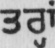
ਤਰ੍ਹਾਂ
